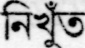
নিখুঁত
